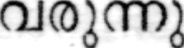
വരുന്നു
